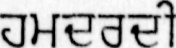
ਹਮਦਰਦੀ
